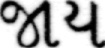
જાય
